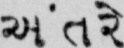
અંતરે
